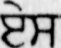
ਏਸ
